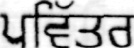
ਪਵਿੱਤਰ
